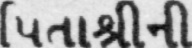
પિતાશ્રીની
